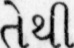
તેથી
